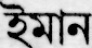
ইমান
